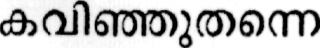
കവിഞ്ഞുതന്നെ
